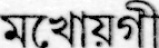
মখোয়গী
